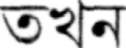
তখন
